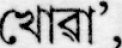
খোৱা',
